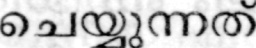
ചെയ്യുന്നത്
